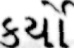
કર્યો
